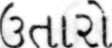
ઉતારો
